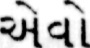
એવો
